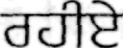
ਰਹੀਏ
